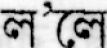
ল'লে
